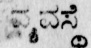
ವ್ಯವಸ್ಥೆ
